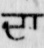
ਦਾ
